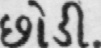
છોડી.
